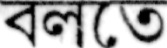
বলতে
